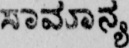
ಸಾಮಾನ್ಯ
